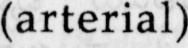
(arterial)
